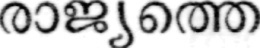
രാജ്യത്തെ
